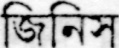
জিনিস
